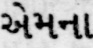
એમના
